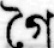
গৈ
